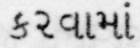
કરવામાં
